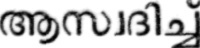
ആസ്വദിച്ച്
